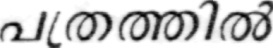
പത്രത്തില്‍
